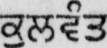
ਕੁਲਵੰਤ
